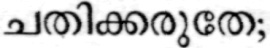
ചതിക്കരുതേ;
